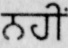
ਨਹੀਂ
